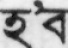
হ'ব
